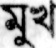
মুখ
